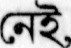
নেই,
